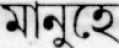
মানুহে
